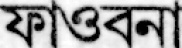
ফাওবনা
